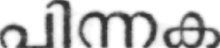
പിന്നക
